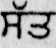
ਸੱਤ
